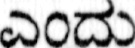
ಎಂದು
